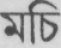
মচি
